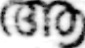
ആ
